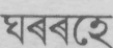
ঘৰৰহে
